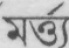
মৰ্ত্ত্য
